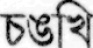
চঙখি
